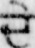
ਦੇ
